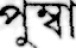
পুম্বা
